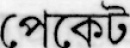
পেকেট
